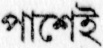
পাশেই
